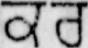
ਕਰ
